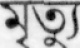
মৃত্যু
